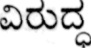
ವಿರುದ್ಧ
